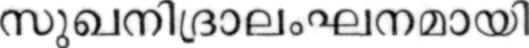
സുഖനിദ്രാലംഘനമായി
